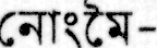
নোংমৈ-
